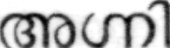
അഗ്നി
